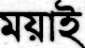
ময়াই
